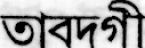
তাবদগী
